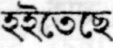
হইতেছে
